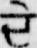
ਦੇ
